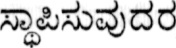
ಸ್ಥಾಪಿಸುವುದರ
